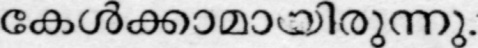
കേള്‍ക്കാമായിരുന്നു.
